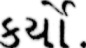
કર્યો.
